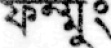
ফম্মুং
